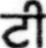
ਟੀ
